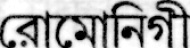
রোমোনিগী
